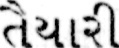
તૈયારી
